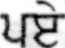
ਪਏ
